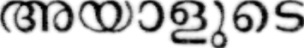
അയാളുടെ
